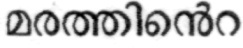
മരത്തിന്റെ
